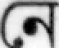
নে
